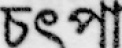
চৎপা
